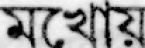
মখোয়
